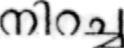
നിറച്ച
